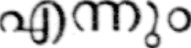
എന്നും
